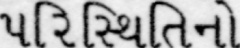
પરિસ્થિતિનો
